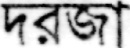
দরজা
